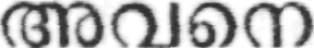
അവനെ
